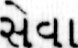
સેવા
